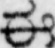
ಈ
